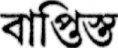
বাপ্তিস্ত
